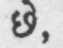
છે,
